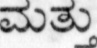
ಮತ್ತು
